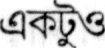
একটুও
